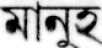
মানুহ
